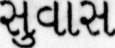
સુવાસ
